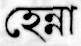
হেন্না
